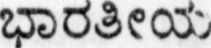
ಭಾರತೀಯ
